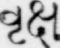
વૃક્ષ
